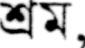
শ্রম,
